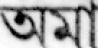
অমা
